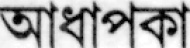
আধাপকা
